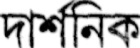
দার্শনিক
